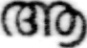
ആ
